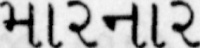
મારનાર
